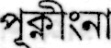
পুক্নীংনা
